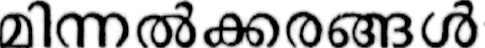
മിന്നല്‍ക്കരങ്ങള്‍
